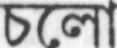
চলো
